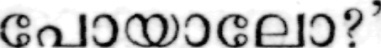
പോയാലോ?'
